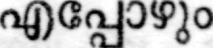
എപ്പോഴും
